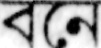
বনে
